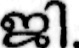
ജി.
